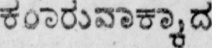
ಕಾರುವಾಕ್ಕಾದ
